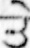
ਤੇ
